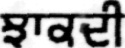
ਝਾਕਦੀ
